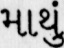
માથું
